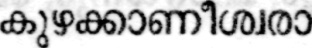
കുഴക്കാണീശ്വരാ
